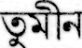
তুমীন
